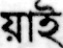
য়াই
